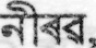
নীৰৱ,
